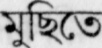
মুছিতে
